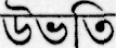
উভতি
